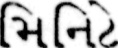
મિનિટે
